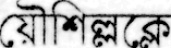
য়ৌশিল্লক্লে
